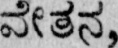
ವೇತನ,
